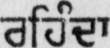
ਰਹਿੰਦਾ
